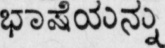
ಭಾಷೆಯನ್ನು
